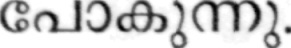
പോകുന്നു.
